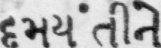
દમયંતીને
